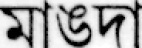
মাঙদা
